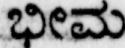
ಭೀಮ
